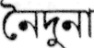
নৈদুনা
